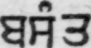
ਬਸੰਤ
